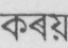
কৰয়
